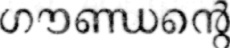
ഗൗണ്ഡന്റെ
